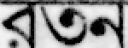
রতন
